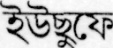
ইউছুফে
